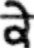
ਕੇ
